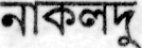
নাকলদু
